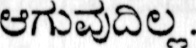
ಆಗುವುದಿಲ್ಲ.
